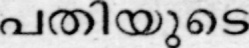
പതിയുടെ
